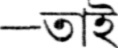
–তাই
